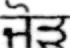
ਜੋੜ
